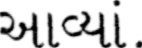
આવ્યાં.
